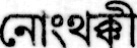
নোংথক্কী
